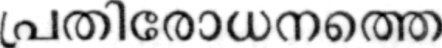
പ്രതിരോധനത്തെ
